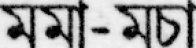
মমা-মচা
